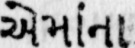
એમાંના
